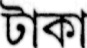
টাকা
